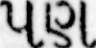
પણ
